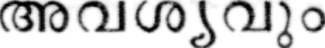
അവശ്യവും
